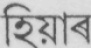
হিয়াৰ
